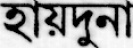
হায়দুনা
